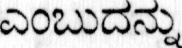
ಎಂಬುದನ್ನು
